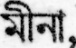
মীনা,
